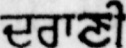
ਦਰਾਣੀ
